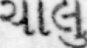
ચાલુ
